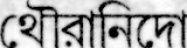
থৌরানিদো
